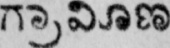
ಗ್ರಾಮೀಣ
